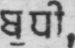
ਬੁਧੀ,
